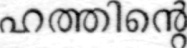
ഹത്തിന്റെ
